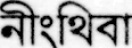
নীংথিবা
